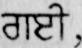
ਗਈ,
